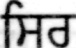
ਸਿਰ
